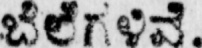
ಬೆಲೆಗಳಿವೆ.
